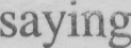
saying
